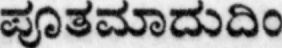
ಪೂತಮಾದುದಿಂ
